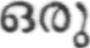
ഒരു
